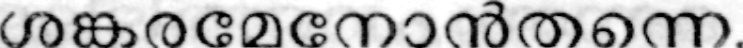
ശങ്കരമേനോന്‍തന്നെ.
